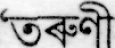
'তৰুণী
